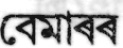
বেমাৰৰ
